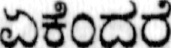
ಏಕೆಂದರೆ
